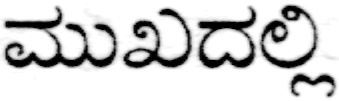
ಮುಖದಲ್ಲಿ
